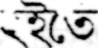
হইতে
